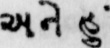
અનેહું
